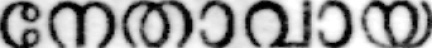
നേതാവായ
